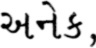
અનેક,
